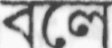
বলে
